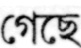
গেছে
